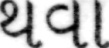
થવા
